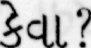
કેવા?
